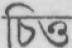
চিত্ত
